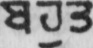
ਬਹੁਤ
